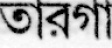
তারগা
